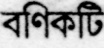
বণিকটি
